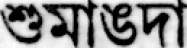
শুমাঙদা
